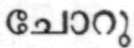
ചോറു
